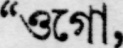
‘‘ওগো,
